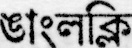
ঙাংলক্লি
